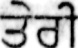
ਤੇਰੀ
